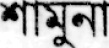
শামুনা
